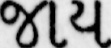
જાય
